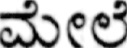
ಮೇಲೆ
